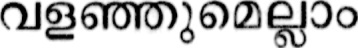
വളഞ്ഞുമെല്ലാം
